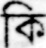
কি
